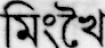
মিংখৈ
